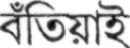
বঁতিয়াই
